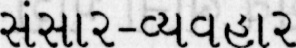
સંસાર-વ્યવહાર
